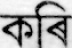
কৰি
